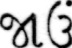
જાઉં
